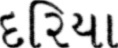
દરિયા
